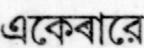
একেবারে
